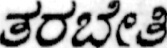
ತರಬೇತಿ
